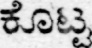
ಕೊಟ್ಟ
